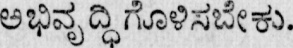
ಅಭಿವೃದ್ಧಿಗೊಳಿಸಬೇಕು.
